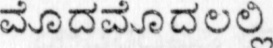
ಮೊದಮೊದಲಲ್ಲಿ
